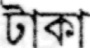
টাকা
